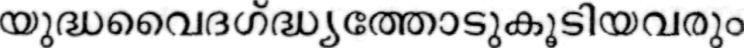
യുദ്ധവൈദഗ്ദ്ധ്യത്തോടുകൂടിയവരും
